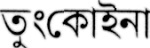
তুংকোইনা
